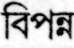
বিপন্ন
